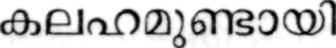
കലഹമുണ്ടായി
